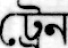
ট্রেন
